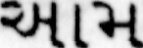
આમ
